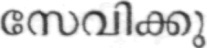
സേവിക്കു
